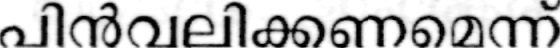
പിന്‍വലിക്കണമെന്ന്
